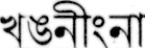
খঙনীংনা
